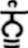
ਨੂੰ
